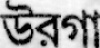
উরগা
